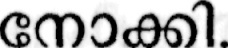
നോക്കി.
